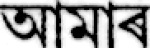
আমাৰ
